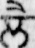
ਲੈ
